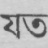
যত
